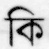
কি
